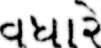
વધારે
